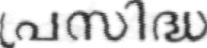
പ്രസിദ്ധ
